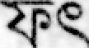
ফৎ
